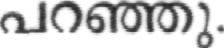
പറഞ്ഞു.
